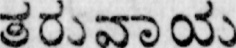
ತರುವಾಯ
